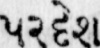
પરદેશ
